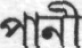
পানী
